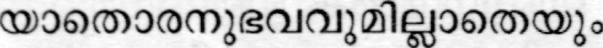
യാതൊരനുഭവവുമില്ലാതെയും
